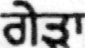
ਗੇੜਾ
